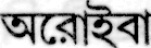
অরোইবা
